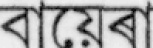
বায়েৰা
